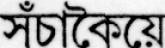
সঁচাকৈয়ে
